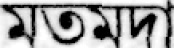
মতমদা
